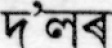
দ'লৰ
